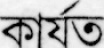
কার্যত
